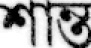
শান্ত
